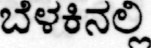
ಬೆಳಕಿನಲ್ಲಿ
